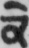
ਕੇ
